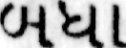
બધા
